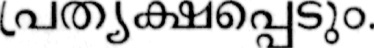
പ്രത്യക്ഷപ്പെടും.
